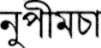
নুপীমচা
